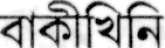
বাকীখিনি
